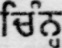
ਚਿੰਨ੍ਹ
